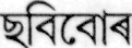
ছবিবোৰ
